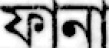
ফানা
